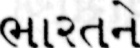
ભારતને
